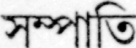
সম্পাতি
